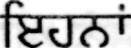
ਇਹਨਾਂ
